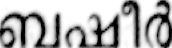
ബഷീര്‍
